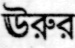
ঊরুর
